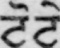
ਟੋਟੇ
